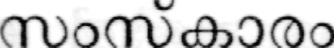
സംസ്കാരം
